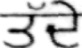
ਤੱਦੇ
